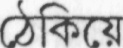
ঠেকিয়ে
